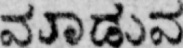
ಮಾಡುವ
